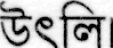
উৎলি।
